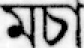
মচা
